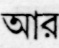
আর
